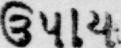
ઉપાય
